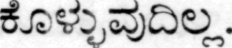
ಕೊಳ್ಳುವುದಿಲ್ಲ.
